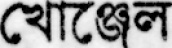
খোঞ্জেল
